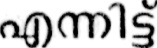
എന്നിട്ട്
